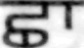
ਛਾ
